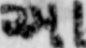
આ
